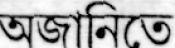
অজানিতে
